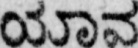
ಯಾವ
